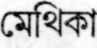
মেথিকা
